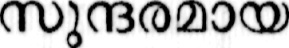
സുന്ദരമായ
